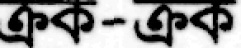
ক্রক-ক্রক
